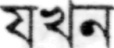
যখন
